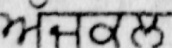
ਅੱਜਕਲ
